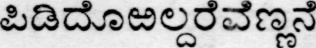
ಪಿಡಿದೊಱಲ್ದರೆವೆಣ್ಣನೆ
